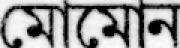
মোমোন
